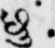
છું.
